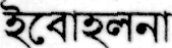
ইবোহলনা
